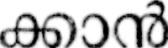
ക്കാന്‍
